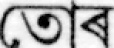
তোৰ
